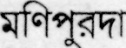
মণিপুরদা
